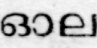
ഓല
